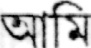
আমি
